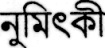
নুমিৎকী
